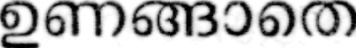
ഉണങ്ങാതെ
